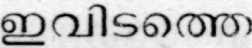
ഇവിടത്തെ
